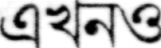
এখনও
